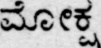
ಮೋಕ್ಷ
